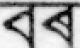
বৰ
